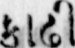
કાઢી
